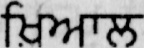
ਖ਼ਿਆਲ
